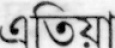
এতিয়া
